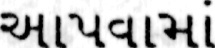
આપવામાં
